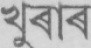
খুৰাৰ
